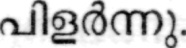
പിളര്‍ന്നു.
